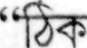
"ঠিক
